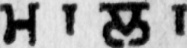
ਮਾਲਾ
